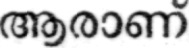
ആരാണ്
